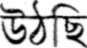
উঠছি
